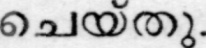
ചെയ്തു.
